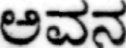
ಅವನ
